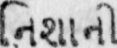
નિશાની
